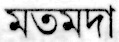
মতমদা
